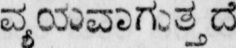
ವ್ಯಯವಾಗುತ್ತದೆ
